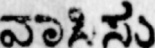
ವಾಸಿಸು
